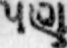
પણ
